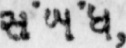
સંબંધ,
